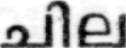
ചില
